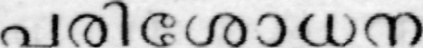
പരിശോധന
